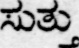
ಸುತ್ತು
